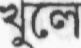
খুলে
